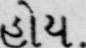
હોય.
